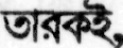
তারকই,
